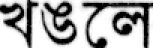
খঙলে
